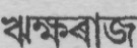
ঋক্ষৰাজ
